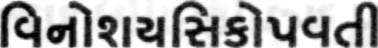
વિનોશયસિકોપવતી
